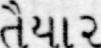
તૈયાર
